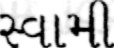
સ્વામી
